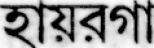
হায়রগা
